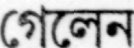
গেলেন
